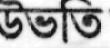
উভতি
